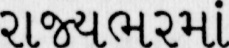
રાજ્યભરમાં
